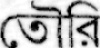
তৌরি
